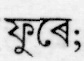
ফুৰে;
